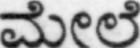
ಮೇಲೆ
